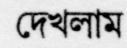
দেখলাম
